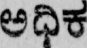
ಅಧಿಕ
